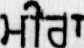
ਮੀਰਾ
